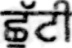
ਛੁੱਟੀ
